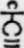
ਨੂੰ
